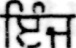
ਇੰਜ
